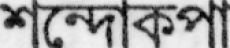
শন্দোকপা
